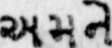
અમને
